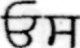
ਓਸ
